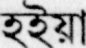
হইয়া
